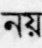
নয়
